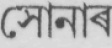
সোনাৰ
